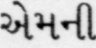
એમની
